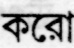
করো
